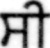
ਸੀ
